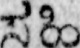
ಸಹಿ
